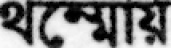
থম্মোয়
